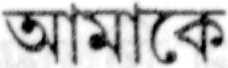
আমাকে
